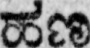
ಹಣ
